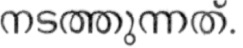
നടത്തുന്നത്.
